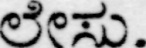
ಲೇಸು.
